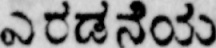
ಎರಡನೆಯ
